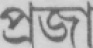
প্ৰজা
